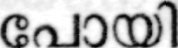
പോയി
